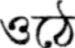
ওঠে
